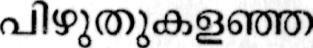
പിഴുതുകളഞ്ഞ
